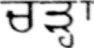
ਚੜ੍ਹਾ
